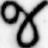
જ
